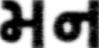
મન
